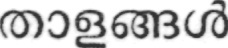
താളങ്ങള്‍
